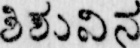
ಶಿಶುವಿನ
